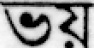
ভয়
